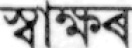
স্বাক্ষৰ
